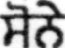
ਸੋਨੇ
